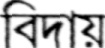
বিদায়
